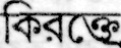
কিহরক্ত্র
